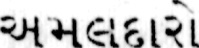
અમલદારો
